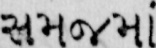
સમજમાં
